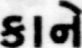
કાને
